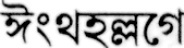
ঈংথহল্লগে
